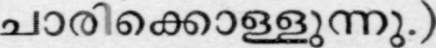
ചാരിക്കൊള്ളുന്നു.)
